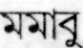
মমাবু
